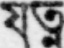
যত্ন
